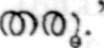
തരൂ.’
